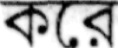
করে
